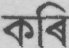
কৰি
